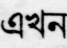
এখন
